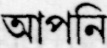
আপনি
